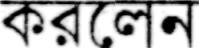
করলেন
